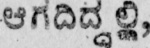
ಆಗದಿದ್ದಲ್ಲಿ,
